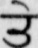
ਤੇ
